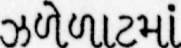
ઝળેળાટમાં
